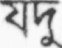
যদু
